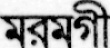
মরমগী
